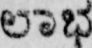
ಲಾಭ
